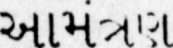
આમંત્રણ
